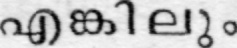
എങ്കിലും
